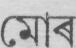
মোৰ
